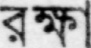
রক্ষা
